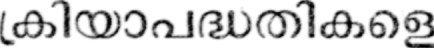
ക്രിയാപദ്ധതികളെ
